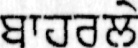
ਬਾਹਰਲੇ
